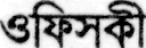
ওফিসগী
